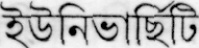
ইউনিভাৰ্ছিটি
